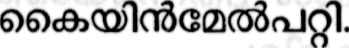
കൈയിന്‍മേല്‍പറ്റി.
